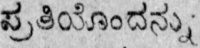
ಪ್ರತಿಯೊಂದನ್ನು
